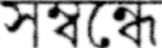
সম্বন্ধে
